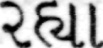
રહ્યા
